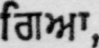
ਗਿਆ,
